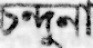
চন্দুনা
